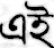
এই
